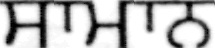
ਸਾਮਾਨ
